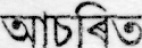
আচৰিত
